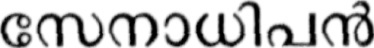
സേനാധിപന്‍
